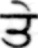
ਤੇ
